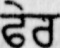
ਫੇਰ
